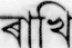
ৰাখি
